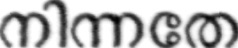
നിന്നതേ
